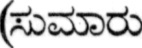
(ಸುಮಾರು
